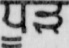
ਧੂੜ
